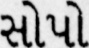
સોપો
